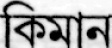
কিমান
